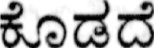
ಕೊಡದೆ
